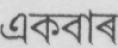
একবাৰ
